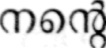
നന്റെ
